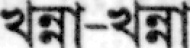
খন্না-খন্না
